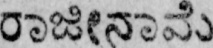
ರಾಜೀನಾಮೆ
